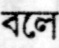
বলে
